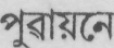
পুৱায়নে
